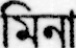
মিনা
